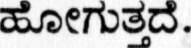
ಹೋಗುತ್ತದೆ.
